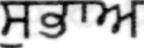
ਸੁਭਾਅ
